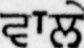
ਵਾਲੇ
